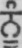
ਨੂੰ
